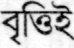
বৃত্তিই
